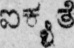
ಐಕ್ಯತೆ
